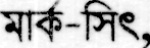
মার্ক-সিৎ,
